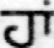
ਹਾਂ
